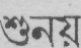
শুনয়
